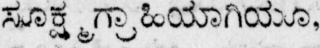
ಸೂಕ್ಷ್ಮಗ್ರಾಹಿಯಾಗಿಯೂ,
